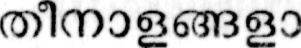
തീനാളങ്ങളാ
